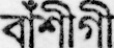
বাঁশীগী
